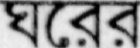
ঘরের
